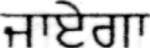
ਜਾਏਗਾ
